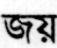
জয়
